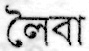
লৈবা
